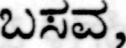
ಬಸವ,
